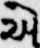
એ
